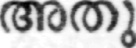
അതു
